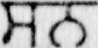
ਸਨ
